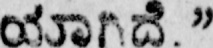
ಯಾಗಿದೆ.”
